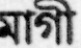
মাগী
